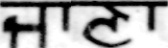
ਜਾਣਾ
